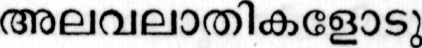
അലവലാതികളോടു
